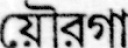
য়ৌরগা
